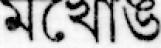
মখোঙ
